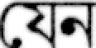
যেন
